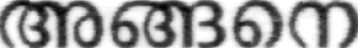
അങ്ങനെ
